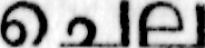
ചെല
